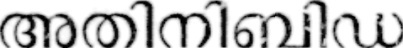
അതിനിബിഡ
